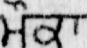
ਮੌਕਾ
